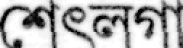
শেৎলগা
